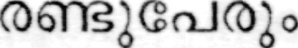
രണ്ടുപേരും
